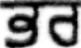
ਭਰ
